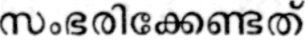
സംഭരിക്കേണ്ടത്
